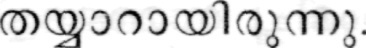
തയ്യാറായിരുന്നു.
